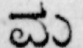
ಮ
